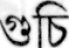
গুচি
